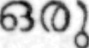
ഒരു
